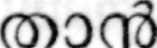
താന്‍
